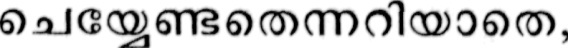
ചെയ്യേണ്ടതെന്നറിയാതെ,
